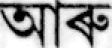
আৰু
